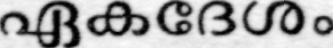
ഏകദേശം
